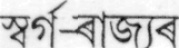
স্বৰ্গ-ৰাজ্যৰ
